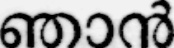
ഞാന്‍
